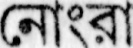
নোংরা
